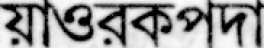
য়াওরকপদা
